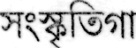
সংস্কৃতিগা
